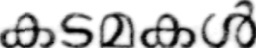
കടമകള്‍
